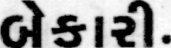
બેકારી.
